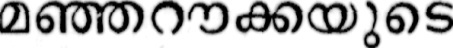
മഞ്ഞറൌക്കയുടെ
